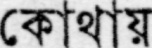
কোথায়
